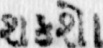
શકશો
